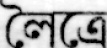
লৈত্রে
